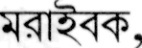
মরাইবক,
